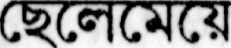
ছেলেমেয়ে
